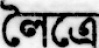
লৈত্রে
